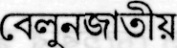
বেলুনজাতীয়
